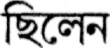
ছিলেন
